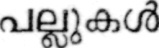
പല്ലുകള്‍
